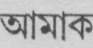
আমাক
